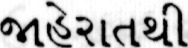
જાહેરાતથી
